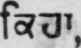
ਕਿਹਾ,
